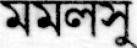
মমলসু
